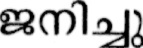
ജനിച്ചു
